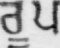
ਰੂਪ
